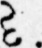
દે.
